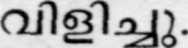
വിളിച്ചു.
